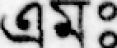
এমঃ
